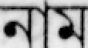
নাম
